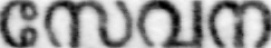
സേവന
